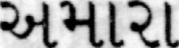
અમારા
